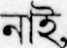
নাই,
